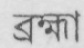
ব্রহ্মা
